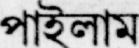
পাইলাম
